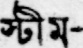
স্টীম-
